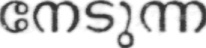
നേടുന്ന
